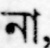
না,
